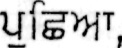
ਪੁਛਿਆ,
